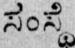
ಸಂಸ್ಥೆ
